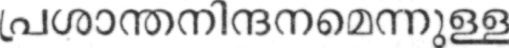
പ്രശാന്തനിന്ദനമെന്നുള്ള
